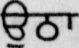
ਉਠਾ
